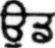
ਉਡ
